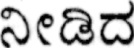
ನೀಡಿದ
